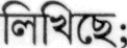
লিখিছে;
